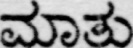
ಮಾತು
